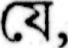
যে,
